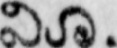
ಮೀ.
